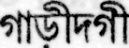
গাড়ীদগী
